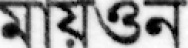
মায়ওন
